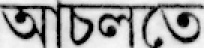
আচলতে
